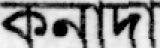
কনাদা
